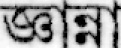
জ্ঞান্না
